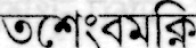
তশেংবমক্নি
